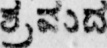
ಶ್ರಮದ
